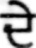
ਦੇ
